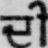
ਦੀ
